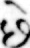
છે
